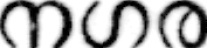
നഗര
